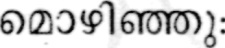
മൊഴിഞ്ഞു:
